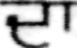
ਦਾ
